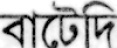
বাটেদি
